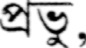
প্রভু,
